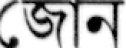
চোন
